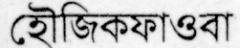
হৌজিকফাওবা
